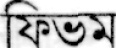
ফিভম
